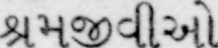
શ્રમજીવીઓ
